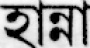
হান্না
